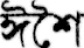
ঈশৈ
